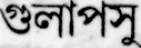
গুলাপসু
